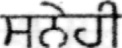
ਸਨੇਹੀ
